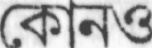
কোনও
